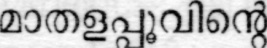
മാതളപ്പൂവിന്റെ
